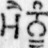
ਮੈਨੂੰ
